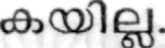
കയില്ല.
